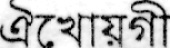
ঐখোয়গী
